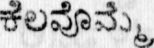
ಕೆಲವೊಮ್ಮೆ
